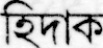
হিদাক
